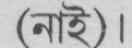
(নাই)।
